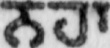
ਨਹਾ
